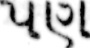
પણ
